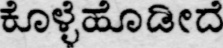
ಕೊಳ್ಳೆಹೊಡೀದೆ
